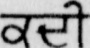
ਕਦੀ
